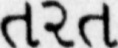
તરત
